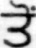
ਤੋਂ
